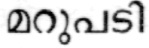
മറുപടി
